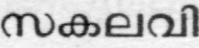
സകലവി
